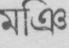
মঞি
